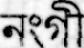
নংগী
